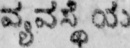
ವ್ಯವಸ್ಥೆಯ
